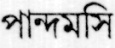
পান্দমসি
